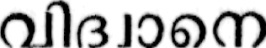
വിദ്വാനെ
